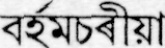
বর্হমচৰীয়া
